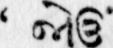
'જોઉં
